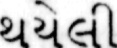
થયેલી
